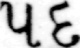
પદ
